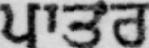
ਪਾਤਰ
